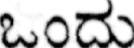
ಒಂದು
